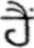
ਹੈਂ
